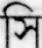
সি
